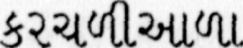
કરચળીઆળા
